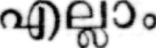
എല്ലാം
